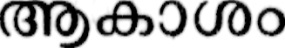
ആകാശം
